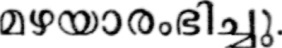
മഴയാരംഭിച്ചു.
